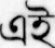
এই
